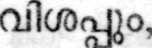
വിശപ്പും,
